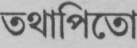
তথাপিতো
